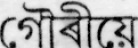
গৌৰীয়ে
